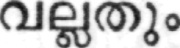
വല്ലതും
